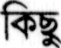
কিছু
